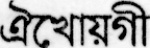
ঐখোয়গী
